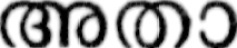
അതാ
